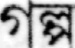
গল্প
